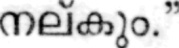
നല്‌കും."
